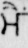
ਮੈਂ
